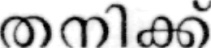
തനിക്ക്
